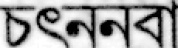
চৎননবা
